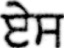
ਏਸ
